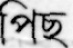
পিছ
